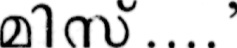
മിസ്....’
